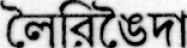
লৈরিঙৈদা
